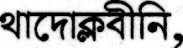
থাদোক্লবীনি,
